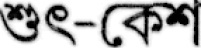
শুৎ-কেশ
